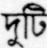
দুটি
